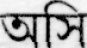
অসি
